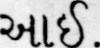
આઈ.
